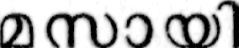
മസായി
